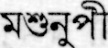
মশুনুপী
